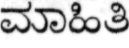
ಮಾಹಿತಿ
